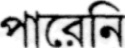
পারেনি
